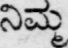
ನಿಮ್ಮ
